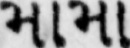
મામા
